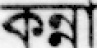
কন্না
